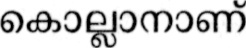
കൊല്ലാനാണ്
